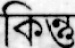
কিন্তু
